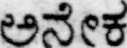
ಅನೇಕ
